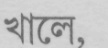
খালে,
